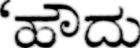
'ಹೌದು
